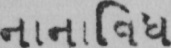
નાનાવિધ
